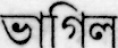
ভাগিল
